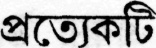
প্রত্যেকটি
